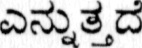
ಎನ್ನುತ್ತದೆ
